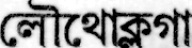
লৌথোক্লগা
